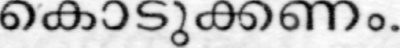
കൊടുക്കണം.
